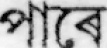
পাৰে
